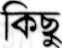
কিছু
